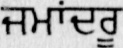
ਜਮਾਂਦਰੂ
